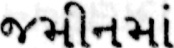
જમીનમાં
